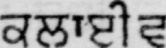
ਕਲਾਈਵ
